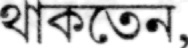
থাকতেন,
